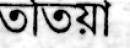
ততিয়া
